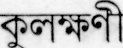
কুলক্ষণী
